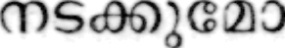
നടക്കുമോ
